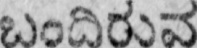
ಬಂದಿರುವ
